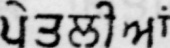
ਪੇਤਲੀਆਂ
